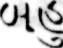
બહુ
